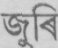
জুৰি
